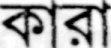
কারা
